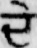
ਦੇ
